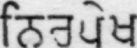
ਨਿਰਪੇਖ
